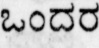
ಒಂದರ
